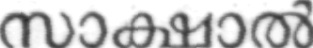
സാക്ഷാല്‍
